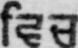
ਵਿਚ
